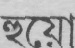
হুয়ো
